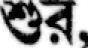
শুর,
